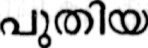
പുതിയ
